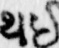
થઈ
